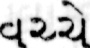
વચ્ચે
